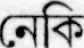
নেকি
